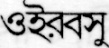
ওইরবসু
